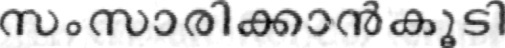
സംസാരിക്കാന്‍കൂടി
